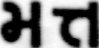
મત્ત
